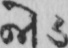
જોડ
